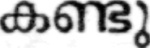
കണ്ടു
